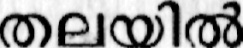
തലയില്‍
